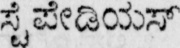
ಸ್ಟೆಪೇಡಿಯಸ್
